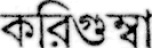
করিগুম্বা
